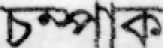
চম্পাক
